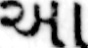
આ
